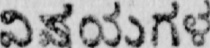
ವಿಷಯಗಳ
